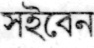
সইবেন
